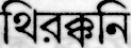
থিরক্কনি
